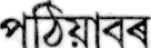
পঠিয়াবৰ
